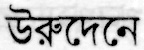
উরুদেনে
